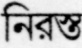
নিরস্ত
